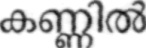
കണ്ണില്‍
